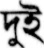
দুই
